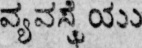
ವ್ಯವಸ್ಥೆಯು
